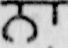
ਨਾ
